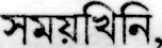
সময়খিনি,
